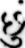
છું
